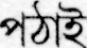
পঠাই
